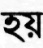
হয়
